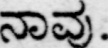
ನಾವು.
